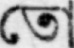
তো
